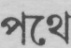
পথে
